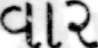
વાર
